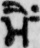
ਮੈਂ
